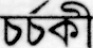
চর্চকী
